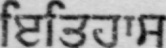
ਇਤਿਹਾਸ
